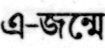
এ-জন্মে
